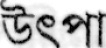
উৎপা
